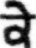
ਕੇ
